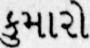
કુમારો
